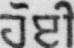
ਹੋਈ
